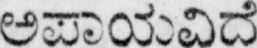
ಅಪಾಯವಿದೆ
